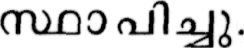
സ്ഥാപിച്ചു.
